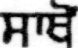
ਸਾਥੋਂ
